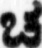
ಚ
